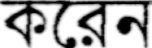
করেন
